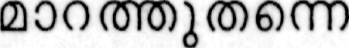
മാറത്തുതന്നെ
